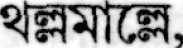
থল্ল্মাল্লে,
